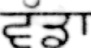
ਵੱਡਾ
